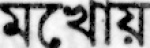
মখোয়
